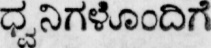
ಧ್ವನಿಗಳೊಂದಿಗೆ
